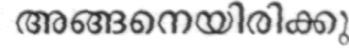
അങ്ങനെയിരിക്കു
